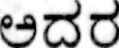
ಅದರ
